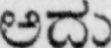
ಅದು
